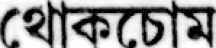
থোকচোম
